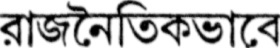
রাজনৈতিকভাবে
